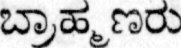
ಬ್ರಾಹ್ಮಣರು
